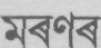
মৰণৰ
